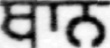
ਥਾਨ
